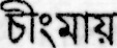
চীংমায়
